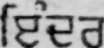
ਇੰਦਰ
